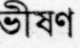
ভীষণ
